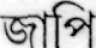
জাপি
